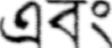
এবং
